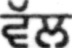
ਵੱਲ
